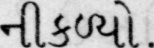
નીકળ્યો.
